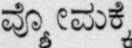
ವ್ಯೋಮಕ್ಕೆ
